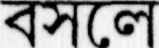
বসলে
